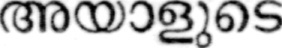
അയാളുടെ
